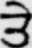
ਤੇ
